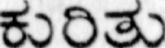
ಕುರಿತು
